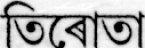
তিৰোতা
